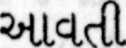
આવતી
